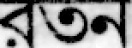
রতন
